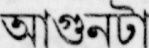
আগুনটা
